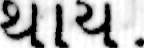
થાય.
